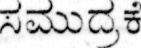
ಸಮುದ್ರಕೆ
